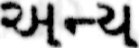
અન્ય
